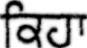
ਕਿਹਾ
